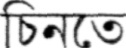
চিনতে
